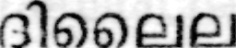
ദിലൈല
